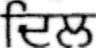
ਦਿਲ
